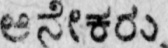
ಅನೇಕರು
